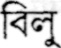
বিলু
